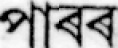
পাৰৰ
